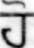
ਹੋ
